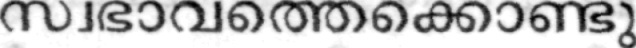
സ്വഭാവത്തെക്കൊണ്ടു
